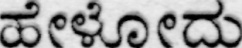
ಹೇಳೋದು
